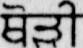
ਥੋੜੀ
